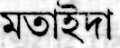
মতাইদা
